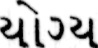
યોગ્ય
